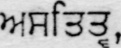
ਅਸਤਿਤ੍ਵ,
